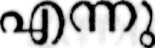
എന്നു
